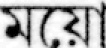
ময়ো
